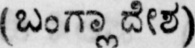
(ಬಂಗ್ಲಾದೇಶ)
